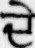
ਦੇ
